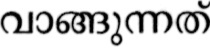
വാങ്ങുന്നത്
